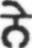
ਨੇ
